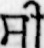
ਸੀ
